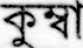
কুম্বা
